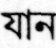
যান
